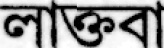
লাক্তবা
